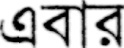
এবার
